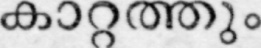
കാറ്റത്തും
